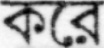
করে
